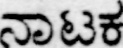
ನಾಟಕ
